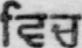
ਵਿਚ
